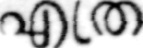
എത്ര
